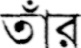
তাঁর
